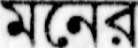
মনের
